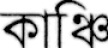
কাঞ্চি
